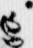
હું
